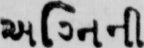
અગ્નિની
